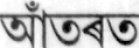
আঁতৰত
